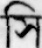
সি
